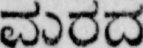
ಮರದ
